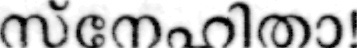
സ്നേഹിതാ!
